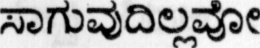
ಸಾಗುವುದಿಲ್ಲವೋ
